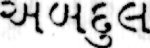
અબદુલ
